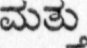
ಮತ್ತು
